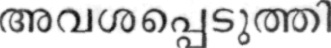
അവശപ്പെടുത്തി
